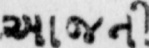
આજની
